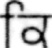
ਕਿ
